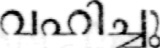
വഹിച്ചു
